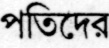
পতিদের
